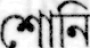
শোনি
